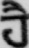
ਹੈ
